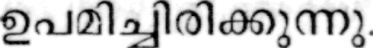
ഉപമിച്ചിരിക്കുന്നു.
